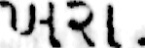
ખરા.
